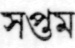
সপ্তম
